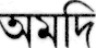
অমদি
